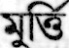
মুর্ত্তি
